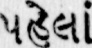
પહેલાં
